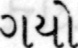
ગયો
